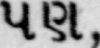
પણ,
